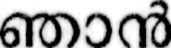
ഞാന്‍
